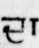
ਦਾ
